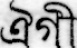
ঐগী
